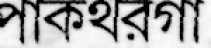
পাকথরগা
